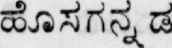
ಹೊಸಗನ್ನಡ
